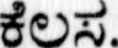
ಕೆಲಸ.
